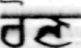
ਰੋਣ
